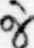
જે
